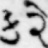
કરે
